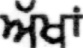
ਅੱਖਾਂ
